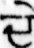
ਦੇ
